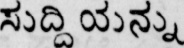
ಸುದ್ದಿಯನ್ನು
